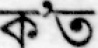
ক'ত
